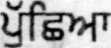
ਪੁੱਛਿਆ
